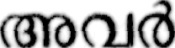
അവര്‍
